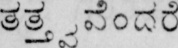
ತತ್ತ್ವವೆಂದರೆ
